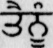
ਤੈਨੂੰ
